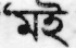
"মই
